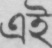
এই
